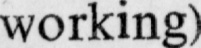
working)
